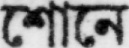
শোনে
